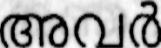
അവര്‍
